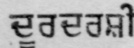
ਦੂਰਦਰਸ਼ੀ,
